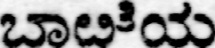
ಬಾೞೆಯ
